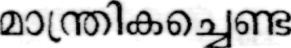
മാന്ത്രികച്ചെണ്ട
